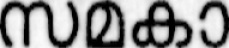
സമകാ
